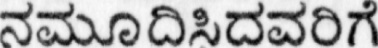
ನಮೂದಿಸಿದವರಿಗೆ
